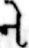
ને
